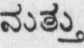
ಮತ್ತು
